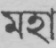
মহা
